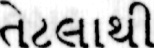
તેટલાથી
